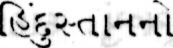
હિંદુસ્તાનનો
